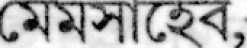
মেমসাহেব,
